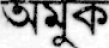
অমুক
